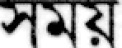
সময়
